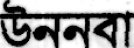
উননবা
